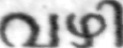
വഴി
